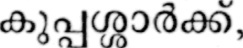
കുപ്പശ്ശാര്‍ക്ക്,
